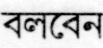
বলবেন
